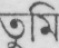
তুমি
